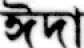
ঈদা
